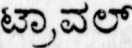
ಟ್ರಾವಲ್
